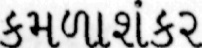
કમળાશંકર
